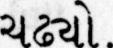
ચઢ્યો.
